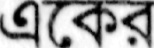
একের
